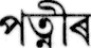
পত্নীৰ
